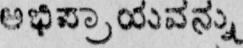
ಅಭಿಪ್ರಾಯವನ್ನು
